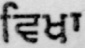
ਵਿਖਾ
